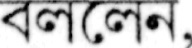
বললেন,
